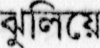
ঝুলিয়ে
